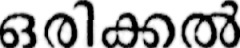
ഒരിക്കല്‍
